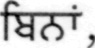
ਬਿਨਾਂ,
